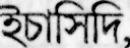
ইচাসিদি,
